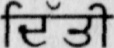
ਦਿੱਤੀ
